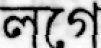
লগে
